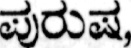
ಪುರುಷ,
